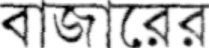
বাজারের
